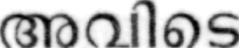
അവിടെ
